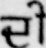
ਦੀ
